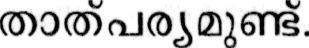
താത്പര്യമുണ്ട്.
